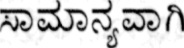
ಸಾಮಾನ್ಯವಾಗಿ
